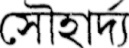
সৌহার্দ্য
